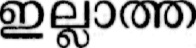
ഇല്ലാത്ത
